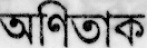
অণিতাক
